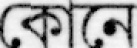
কোনে
